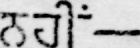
ਨਹੀਂ-
